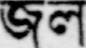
জল
